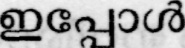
ഇപ്പോള്‍
